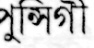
পুন্সিগী
